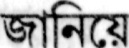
জানিয়ে
